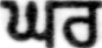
ਘਰ
